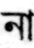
না
